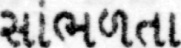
સાંભળતા
